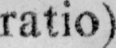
ratio)
